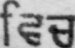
ਵਿਚ
